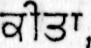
ਕੀਤਾ,
